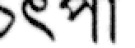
চৎপা
